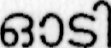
ഓടി
